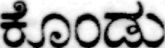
ಕೊಂಡು
